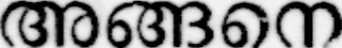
അങ്ങനെ
